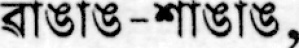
ৱাঙাঙ-শাঙাঙ,
